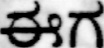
ಈಗ
